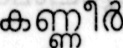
കണ്ണീര്‍
